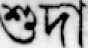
শুদা
